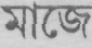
মাজে
